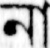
না
